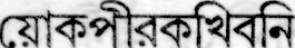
য়োকপীরকখিবনি
